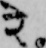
રે.
